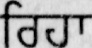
ਰਿਹਾ
